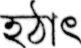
হঠাৎ
